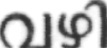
വഴി
